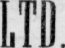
LTD.
